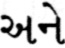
અને
